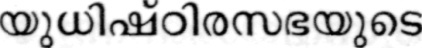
യുധിഷ്ഠിരസഭയുടെ
